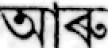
আৰু
